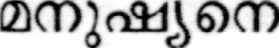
മനുഷ്യനെ
